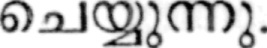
ചെയ്യുന്നു.
